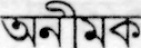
অনীমক
